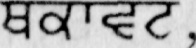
ਥਕਾਵਟ,
